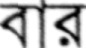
বার
